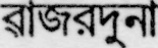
ৱাজরদুনা
